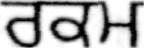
ਰਕਮ
